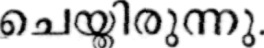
ചെയ്തിരുന്നു.
